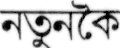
নতুনকৈ
